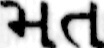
મત
